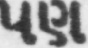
પણ
